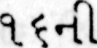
૧૬ની
